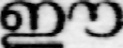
ഈ
